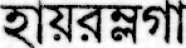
হায়রম্লগা
